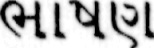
ભાષણ
